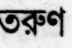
তরুণ
